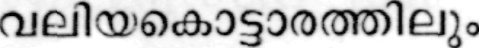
വലിയകൊട്ടാരത്തിലും
